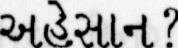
અહેસાન?
